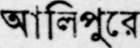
আলিপুরে
